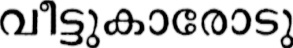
വീട്ടുകാരോടു
